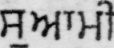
ਸੁਆਮੀ
